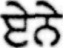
ਏਨੇ
